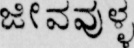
ಜೀವವುಳ್ಳ
